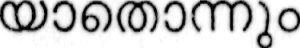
യാതൊന്നും
